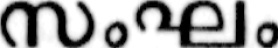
സംഘം
